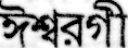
ঈশ্বরগী
